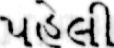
પહેલી
